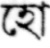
হো
